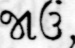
જાઉં,
